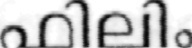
ഫിലിം
